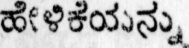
ಹೇಳಿಕೆಯನ್ನು
